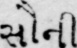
સૌની
